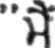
''ਮੈਂ
